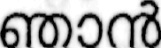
ഞാന്‍
